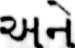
અને
